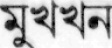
মুখখন
